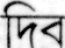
দিব
